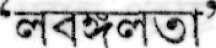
‘লবঙ্গলতা’
